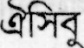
ঐসিবু
